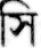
সি
